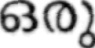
ഒരു
